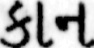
કાન
